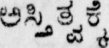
ಅಸ್ತಿತ್ವಕ್ಕೆ
